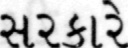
સરકારે
